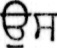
ਉਸ
